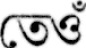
তেওঁ
